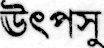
ঊৎপসু
